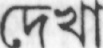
দেখা
